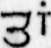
ਤਾਂ
